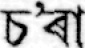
চ'ৰা
